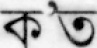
ক'ত
